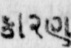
કારણ
